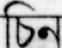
চিন
